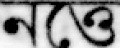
নত্তে
